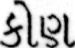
કોણ
